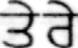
ਤੇਰੇ
